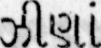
ઝીણાં
